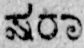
ಷರಾ
